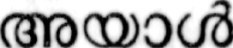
അയാള്‍
